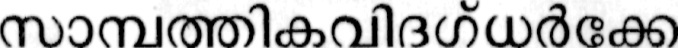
സാമ്പത്തികവിദഗ്ധര്‍ക്കേ
